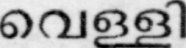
വെള്ളി
